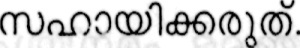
സഹായിക്കരുത്.
